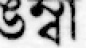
ঙম্বা
